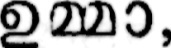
ഉമ്മാ,
